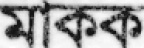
মাকক
